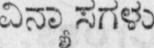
ವಿನ್ಯಾಸಗಳು
